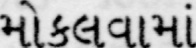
મોકલવામાં
